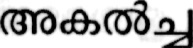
അകല്‍ച്ച
